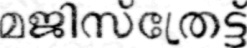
മജിസ്ത്രേട്ട്
